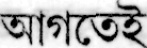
আগতেই
